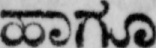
ಹಾಗೂ
